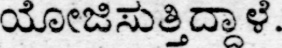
ಯೋಜಿಸುತ್ತಿದ್ದಾಳೆ.
